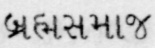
બ્રહ્મસમાજ
